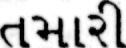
તમારી
